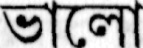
ভালো
